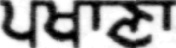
ਪਖਾਣਾ
